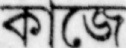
কাজে
